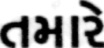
તમારે
